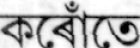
কৰোঁতে
